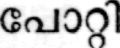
പോറ്റി
